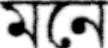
মনে
